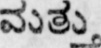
ಮತ್ತು
